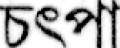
চৎপা
